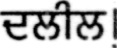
ਦਲੀਲ!
